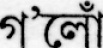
গ'লোঁ
